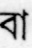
বা
